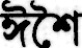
ঈশৈ
